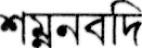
শম্ননবদি
